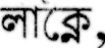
লাক্লে,
